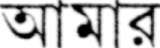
আমার
